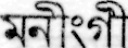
মনীংগী
